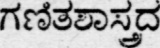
ಗಣಿತಶಾಸ್ತ್ರದ
